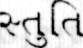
સ્તુતિ
